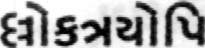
લ્લોકત્રયોપિ
